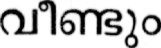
വീണ്ടും
